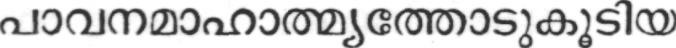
പാവനമാഹാത്മ്യത്തോടുകൂടിയ
